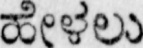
ಹೇಳಲು
